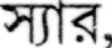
স্যার,
